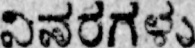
ವಿವರಗಳು
